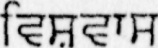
ਵਿਸ਼ਵਾਸ
